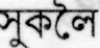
সুকলৈ
